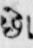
છો
